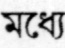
মধ্যে
